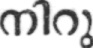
നിറു
